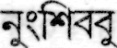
নুংশিববু
